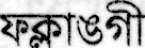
ফক্লাঙগী
